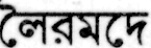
লৈরমদে
